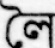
লৈ
